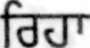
ਰਿਹਾ
